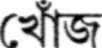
খোঁজ
